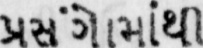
પ્રસંગોમાંથી
